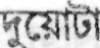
দুয়োটা
